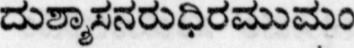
ದುಶ್ಯಾಸನರುಧಿರಮುಮಂ
